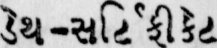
ડેથ-સર્ટિફીકેટ
